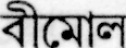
বীমোল
